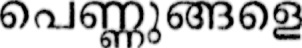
പെണ്ണുങ്ങളെ
